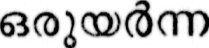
ഒരുയര്‍ന്ന
